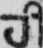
ਹੀ
